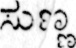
ಸುಣ್ಣ
